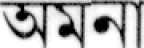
অমনা
